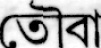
তৌবা
